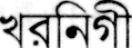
খরনিগী
